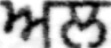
ਅਲ
